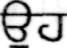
ਉਹ
